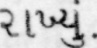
રાખ્યું.
